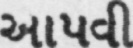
આપવી
